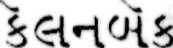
કૅલનબૅક
